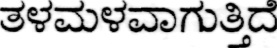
ತಳಮಳವಾಗುತ್ತಿದೆ
